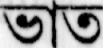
ভাত
